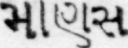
માણસ
